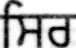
ਸਿਰ
